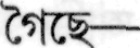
গৈছে-
